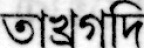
তাখ্রগদি
